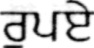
ਰੁਪਏ
